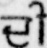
ਦੀ
